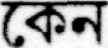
কেন
